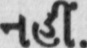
નહીં.
